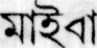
মাইবা
